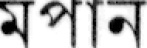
মপান
